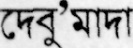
দেবু’মাদা
